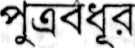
পুত্রবধূর
